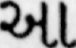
આ
